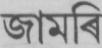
জামৰি
